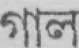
গাল
